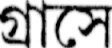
গ্রাসে
